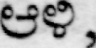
ಆಳಿ,
